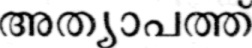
അത്യാപത്ത്
